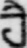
ਹੈ
